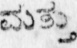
ಮತ್ತು
